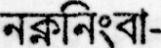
নক্ননিংবা-
